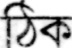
ঠিক
